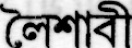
লৈশাবী
